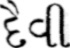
દૈવી
